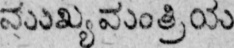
ಮುಖ್ಯಮಂತ್ರಿಯ
